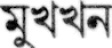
মুখখন
